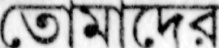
তোমাদের
